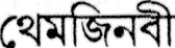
থেমজিনবী
